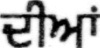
ਦੀਆਂ
